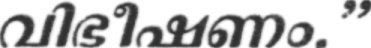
വിഭീഷണം."
